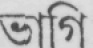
ভাগি
